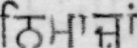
ਨਿਮਾਜ਼ਾਂ
